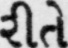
રીતે
